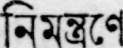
নিমন্ত্রণে
